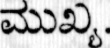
ಮುಖ್ಯ.
